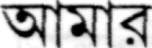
আমার
